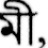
মী,
